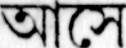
আসে
